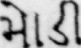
મોડી
